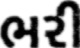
ભરી
